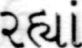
રહ્યાં
